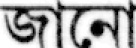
জানো
